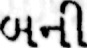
બની
